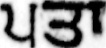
ਪਤਾ
